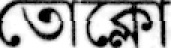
তোক্লো
